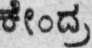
ಕೇಂದ್ರ
